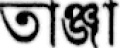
তাঞ্জা
